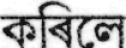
কৰিলে
